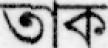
তাক
